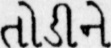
તોડીને
